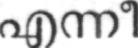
എന്നീ
